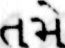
તમે
